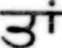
ਤਾਂ
